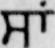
ਸਾਂ
